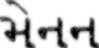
મેનન
